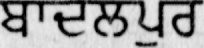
ਬਾਦਲਪੁਰ
